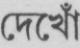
দেখোঁ
